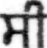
ਸੀ
